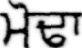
ਮੋਢਾ
